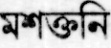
মশক্তনি
